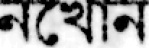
নখোন
